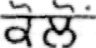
ਕੋਲੋਂ
